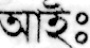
আইঃ
